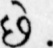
છે.
